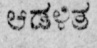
ಆಡಳಿತ
